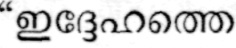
“ഇദ്ദേഹത്തെ
